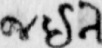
જઈને
